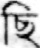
ছি
